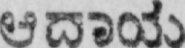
ಆದಾಯ
